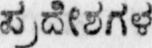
ಪ್ರದೇಶಗಳ
